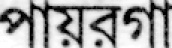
পায়রগা
